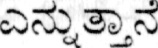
ಎನ್ನುತ್ತಾನೆ
